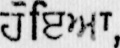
ਹੋਇਆ,
